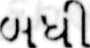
બધી
